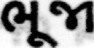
ભૂજા
